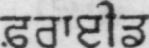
ਫ਼ਰਾਈਡ
